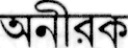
অনীরক
